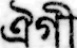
ঐগী
